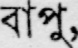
বাপু,
